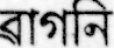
ৱাগনি
